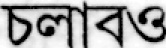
চলাবও
